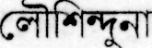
লৌশিন্দুনা
